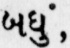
બધું,
